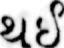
થઈ
